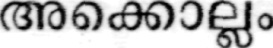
അക്കൊല്ലം
